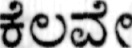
ಕೆಲವೇ
